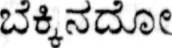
ಬೆಕ್ಕಿನದೋ
